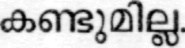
കണ്ടുമില്ല.
